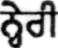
ਨ੍ਹੇਰੀ
